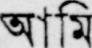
আমি
